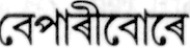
বেপাৰীবোৰে
